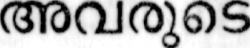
അവരുടെ
